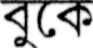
বুকে
